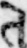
તે
